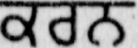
ਕਰਨ
